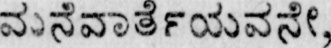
ಮನೆವಾರ್ತೆಯವನೇ,
